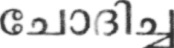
ചോദിച്ച
